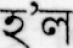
হ'ল
